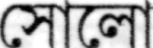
সোলো
